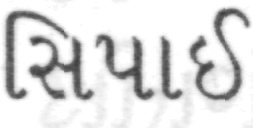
સિપાઈ
